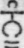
ਨੂੰ
